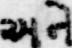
અને
